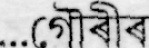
...গৌৰীৰ
